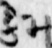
કેમ
